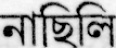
নাছিলি
